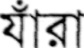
যাঁরা
